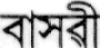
বাসৱী
